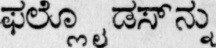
ಫಲ್ಲೊ ಡಸ್‌ನ್ನು
